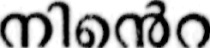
നിന്റെ
